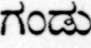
ಗಂಡು
